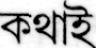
কথাই
